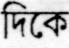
দিকে
